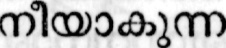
നീയാകുന്ന
